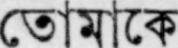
তোমাকে
